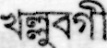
খল্লুবগী
